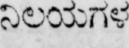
ನಿಲಯಗಳ
